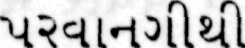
પરવાનગીથી
